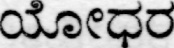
ಯೋಧರ
